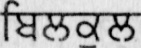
ਬਿਲਕੁਲ
